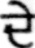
ਦੇ
